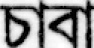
চাবা
